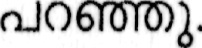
പറഞ്ഞു.
